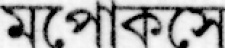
মপোকসে
